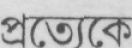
প্ৰত্যেকে
